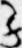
કે
